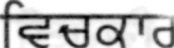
ਵਿਚਕਾਰ
